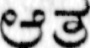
ಆತ
